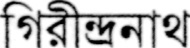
গিরীন্দ্রনাথ
